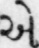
એ
